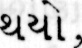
થયો,
